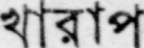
খারাপ
